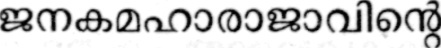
ജനകമഹാരാജാവിന്റെ
